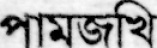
পামজখি
